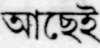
আছেই
